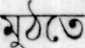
মুঠতে
